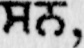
ਸਨ,
